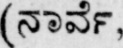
(ನಾರ್ವೆ,
